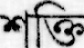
শক্তি
